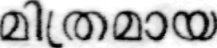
മിത്രമായ
